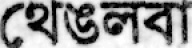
থেঙলবা
